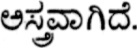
ಅಸ್ತ್ರವಾಗಿದೆ.
